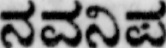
ನವನಿಪ
